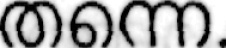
തന്നെ.
